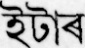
ইটাৰ
